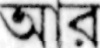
আর
